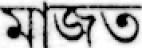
মাজত
